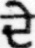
ਦੇ
